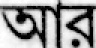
আর
